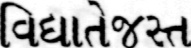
વિદ્યાતેજસ્ત
